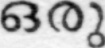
ഒരു
